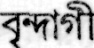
বৃন্দাগী
